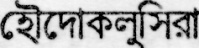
হৌদোকলুসিরা
